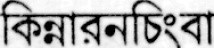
কিন্নারনচিংবা
